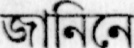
জানিনে
